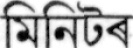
মিনিটৰ
